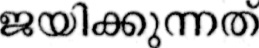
ജയിക്കുന്നത്
